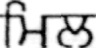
ਮਿਲ
